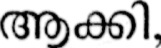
ആക്കി,
